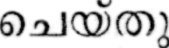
ചെയ്തു
